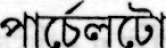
পাৰ্চেলটো
